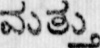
ಮತ್ತು
